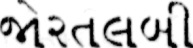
જોરતલબી
